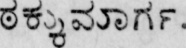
ಠಕ್ಕುಮಾರ್ಗ.
